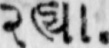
રહ્યા.
